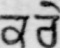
ਕਰੇ
